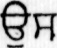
ਉਸ
